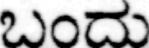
ಬಂದು
